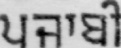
ਪਜਾਬੀ
